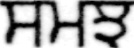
ਸਮਝ
